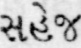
સહેજ
